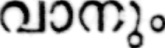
വാനും
